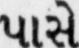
પાસે
